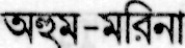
অহুম-মরিনা
